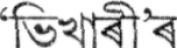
'ভিখাৰী'ৰ
